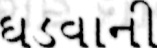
ઘડવાની
